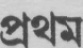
প্ৰথম
